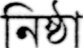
নিষ্ঠা
